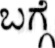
ಬಗ್ಗೆ
